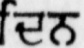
ਦਿਨ
